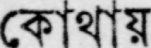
কোথায়
